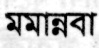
মমান্নবা
